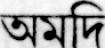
অমদি
